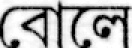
বোলে
